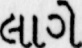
લાગે
